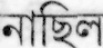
নাছিল
